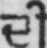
ਦੀ
